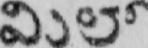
ಮಿಲ್
